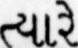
ત્યારે
